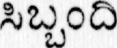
ಸಿಬ್ಬಂದಿ
